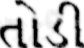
તોડી
